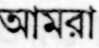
আমরা
